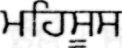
ਮਹਿਸੂਸ
